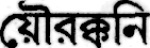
য়ৌরক্কনি
